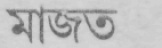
মাজত
